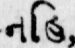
નહિ.
